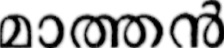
മാത്തന്‍
